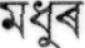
মধুৰ
